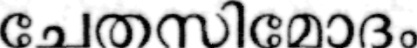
ചേതസിമോദം
